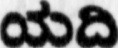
ಯದಿ
